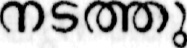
നടത്തു
